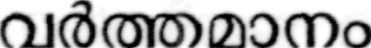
വര്‍ത്തമാനം
